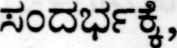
ಸಂದರ್ಭಕ್ಕೆ,
